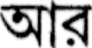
আর
